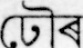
ঢৌৰ
